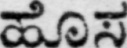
ಹೊಸ
